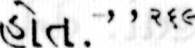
હોત."૨૬૯
